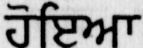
ਹੋਇਆ
